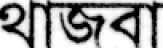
থাজবা
